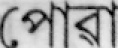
পোৱা
